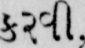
કરવી,
